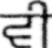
ਵੀ
